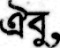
ঐবু,
